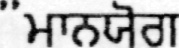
''ਮਾਨਯੋਗ
